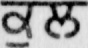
ਕੁਲ
